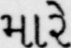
મારે
